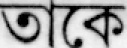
তাকে
